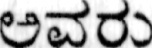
ಅವರು
